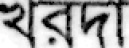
খরদা
